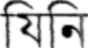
যিনি
